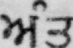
ਅੰਤ
